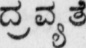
ದ್ರವ್ಯತೆ
